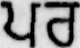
ਪਰ
